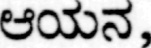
ಆಯನ,
